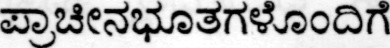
ಪ್ರಾಚೀನಭೂತಗಳೊಂದಿಗೆ
